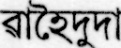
ৱাহৈদুদা
